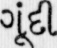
ગૂંદી
